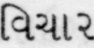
વિચાર
